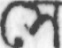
সে
